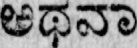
ಅಥವಾ
